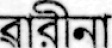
ৱারীনা
